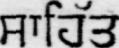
ਸਾਹਿੱਤ
